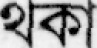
থকা
